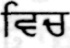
ਵਿਚ
